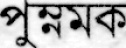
পুম্নমক
